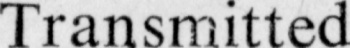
Transmitted
